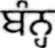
ਬੰਨ੍ਹ
